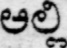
ಅಲ್ಲಿ
